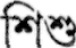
শিশু
